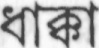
ধাক্কা
